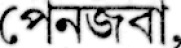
পেনজবা,
